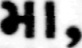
મા,
